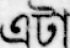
এটা
